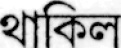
থাকিল
